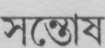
সন্তোষ
